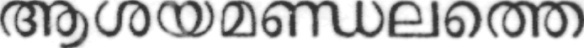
ആശയമണ്ഡലത്തെ
